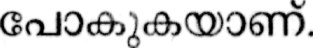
പോകുകയാണ്.
